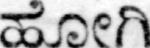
ಹೋಗಿ
